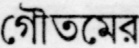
গৌতমের
